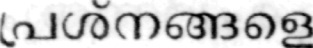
പ്രശ്നങ്ങളെ
